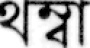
থম্বা
